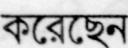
করেছেন
